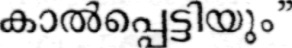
കാല്‍പ്പെട്ടിയും”
